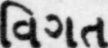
વિગત
